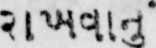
રાખવાનું
